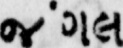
જંગલ
